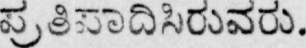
ಪ್ರತಿಪಾದಿಸಿರುವರು.
